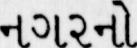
નગરનો
